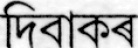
দিবাকৰ
